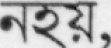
নহয়,
